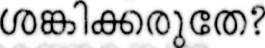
ശങ്കിക്കരുതേ?
